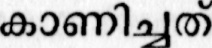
കാണിച്ചത്
